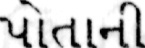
પોતાની
